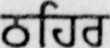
ਠਹਿਰ
